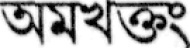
অমখক্তং
